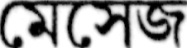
মেসেজ
